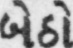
બેઠો
